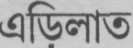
এড়িলাত
